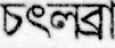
চৎলব্রা
